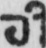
ਹੀ
